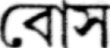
বোস
